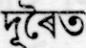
দূৰৈত
